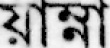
য়াম্না
